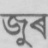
জুৰ
